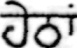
ਹੇਠਾਂ
